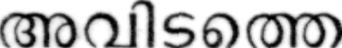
അവിടത്തെ
